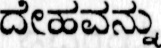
ದೇಹವನ್ನು
